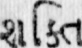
શક્તિ
